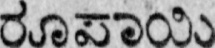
ರೂಪಾಯಿ
